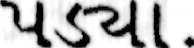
પડ્યા.
